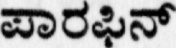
ಪಾರಫಿನ್
